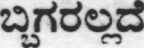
ಬ್ಬಿಗರಲ್ಲದೆ
